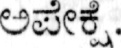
ಅಪೇಕ್ಷೆ.
